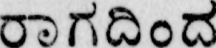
ರಾಗದಿಂದ
